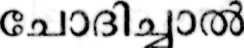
ചോദിച്ചാല്‍
